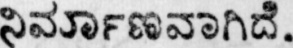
ನಿರ್ಮಾಣವಾಗಿದೆ.
